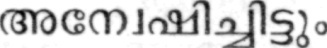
അന്വേഷിച്ചിട്ടും
